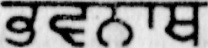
ਭਵਨਾਥ
